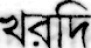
খরদি
